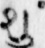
શું
